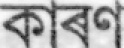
কাৰণ
